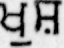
ਖੁਸ਼
